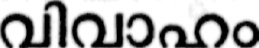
വിവാഹം
